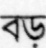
বড়
